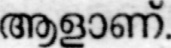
ആളാണ്.
